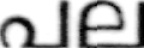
പല
